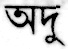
অদু
